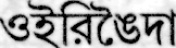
ওইরিঙৈদা
